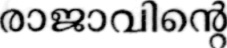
രാജാവിന്റെ
